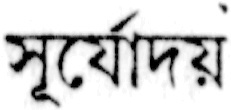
সুর্যোদয়
